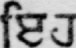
ਇਹ
